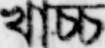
খাচ্চ
